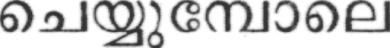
ചെയ്യുമ്പോലെ
